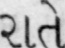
રાતે
